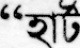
“হার্ট
